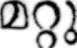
മറ്റു
